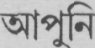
আপুনি
